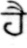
ਹੈ
